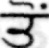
ਤੋਂ
